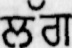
ਲੱਗ
